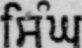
ਸਿੰਘ
